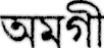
অমগী
